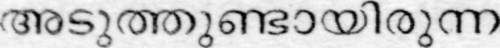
അടുത്തുണ്ടായിരുന്ന
